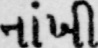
નાંખી
